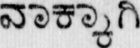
ವಾಕ್ಕಾಗಿ
